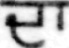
ਦਾ
